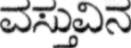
ವಸ್ತುವಿನ
